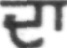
ਦਾ
